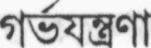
গর্ভযন্ত্রণা
